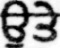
ਉਤੇ
